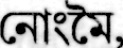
নোংমৈ,
